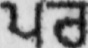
ਪਰ
